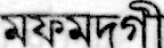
মফমদগী
